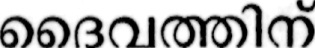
ദൈവത്തിന്
